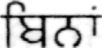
ਬਿਨਾਂ
